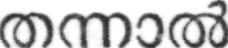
തന്നാല്‍
